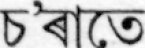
চ'ৰাতে
